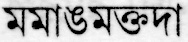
মমাঙমক্তদা
